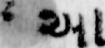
'આ
